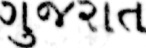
ગુજરાત
